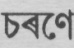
চৰণে
